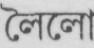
লৈলো
